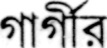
গার্গীর
